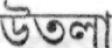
উতলা
